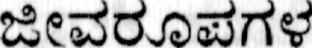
ಜೀವರೂಪಗಳ
